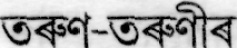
তৰুণ-তৰুণীৰ
